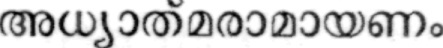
അധ്യാത്മരാമായണം
